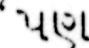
'પણ
